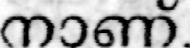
നാണ്.
